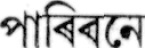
পাৰিবনে
